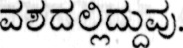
ವಶದಲ್ಲಿದ್ದುವು.
